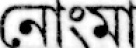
নোংমা
